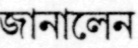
জানালেন
